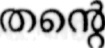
തന്റെ
